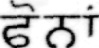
ਫੋਨਾਂ
